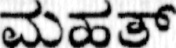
ಮಹತ್
